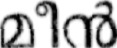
മീന്‍
